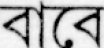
বাবে
